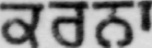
ਕਰਨਾ
